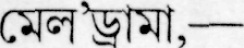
মেল'ড্ৰামা,-
